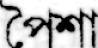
পৈশা
